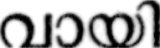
വായി
